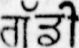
ਗੱਡੀ
